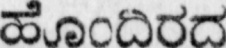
ಹೊಂದಿರದ
